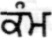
ਕੰਮ
